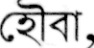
হৌবা,
